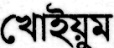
খোইয়ুম
